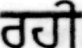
ਰਹੀ
